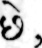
છે,
